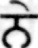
ਨੇ
